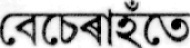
বেচেৰাহঁতে
